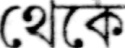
থেকে
